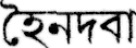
হৈনদবা
